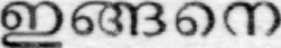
ഇങ്ങനെ
